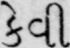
કેવી
